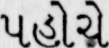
પહોચે
